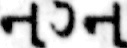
નગ્ન
